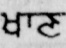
ਖਾਣ
